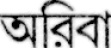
অরিবা
